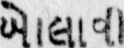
બોલાવી
